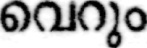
വെറും
